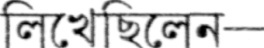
লিখেছিলেন–
